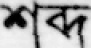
শব্দ
